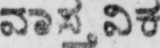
ವಾಸ್ತವಿಕ
